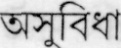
অসুবিধা
